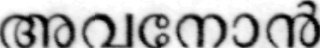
അവനോന്‍
